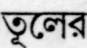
তূলের
